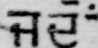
ਜਦੋਂ
